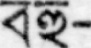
বহু-
